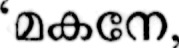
‘മകനേ,
